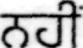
ਨਹੀਂ
